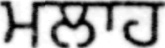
ਮਲਾਹ
